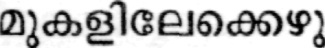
മുകളിലേക്കെഴു
